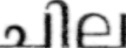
ചില
